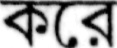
করে
